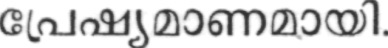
പ്രേഷ്യമാണമായി.
